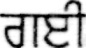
ਗਈ
